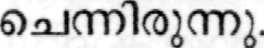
ചെന്നിരുന്നു.
